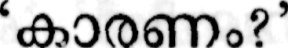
‘കാരണം?’
